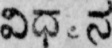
ವಿಧಾನ
